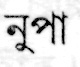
নুপা
